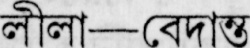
লীলা-বেদান্ত
